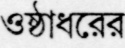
ওষ্ঠাধরের
